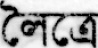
লৈত্রে
